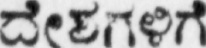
ದೇಶಗಳಿಗೆ
